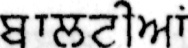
ਬਾਲਟੀਆਂ
